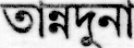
তান্নদুনা
